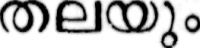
തലയും
